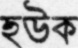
হউক
